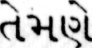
તેમણે
